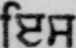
ਇਸ
